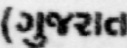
(ગુજરાત
